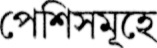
পেশিসমূহে
